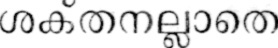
ശക്തനല്ലാതെ
